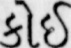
કોઈ
